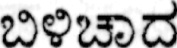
ಬಿಳಿಚಾದ
